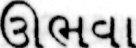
ઊભવા
